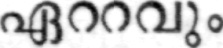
ഏററവും
